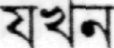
যখন
